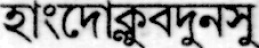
হাংদোক্লুবদুনসু
